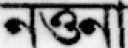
নত্তনা
